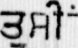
ਤੁਸੀਂ
